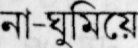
না-ঘুমিয়ে
